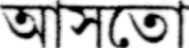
আসতো
